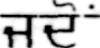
ਜਦੋਂ
